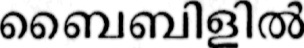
ബൈബിളില്‍
